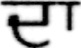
ਦਾ
